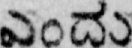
ಎಂದು
